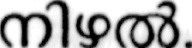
നിഴല്‍.
